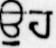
ਉਹ
